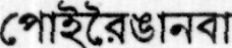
পোইরৈঙানবা
